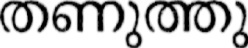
തണുത്തു
